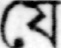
যে
